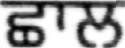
ਛਾਲ
